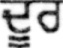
ਦੂਰ
